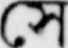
সে
